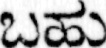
ಬಹು
